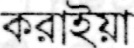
করাইয়া
